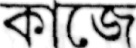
কাজে
